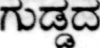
ಗುಡ್ಡದ
